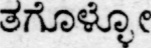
ತಗೊಳ್ಳೋ
